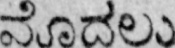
ಮೊದಲು
